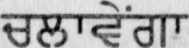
ਚਲਾਵੇਂਗਾ
